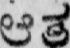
ಆತ
